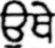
ਉਥੇ
